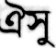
ঐসু
